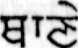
ਥਾਣੇ
